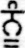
ਨੂੰ
